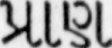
પ્રાણ
